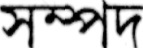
সম্পদ
